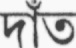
দাঁত
